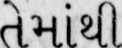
તેમાંથી
